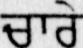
ਚਾਰੇ
